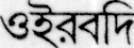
ওইরবদি
